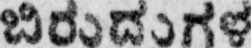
ಬಿರುದುಗಳ
